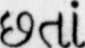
છતાં
